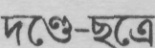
দণ্ডে-ছত্ৰে
